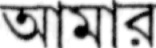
আমার
